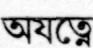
অযত্নে
